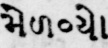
મેળવ્યો
